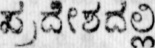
ಪ್ರದೇಶದಲ್ಲಿ
